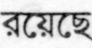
রয়েছে
